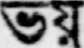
ভয়
